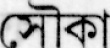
সৌকা
